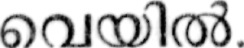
വെയില്‍.
